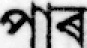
পাৰ
